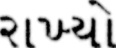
રાખ્યો
